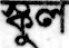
স্কুল
